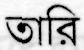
তারি
